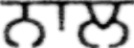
ਨਾਲ
